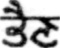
ਭੈਣ
